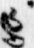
હું
